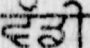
ਵੱਡੀ
